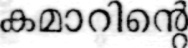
കമാറിന്റെ
